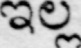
ಇಲ್ಲ
